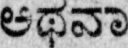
ಅಥವಾ
